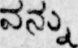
ವನ್ನು
